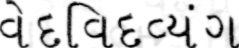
વેદવિદવ્યંગ
